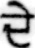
ਦੇ
